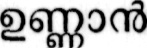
ഉണ്ണാന്‍
